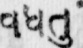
વધતું
